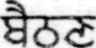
ਬੈਠਣ
